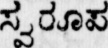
ಸ್ವರೂಪ
